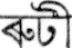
ৰুটী
